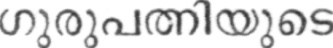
ഗുരുപത്നിയുടെ
